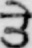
ਤੇ
